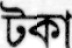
টকা
